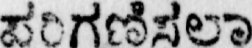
ಪರಿಗಣಿಸಲಾ
